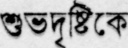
শুভদৃষ্টিকে
